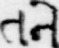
તને
